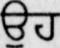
ਉਹ
